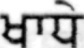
ਖਾਧੇ
